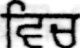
ਵਿਚ
